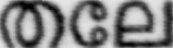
തലേ
